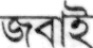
জবাই
